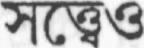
সত্ত্বেও
